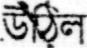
উঠিল
